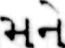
મને
